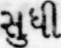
સુધી
